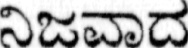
ನಿಜವಾದ
